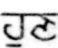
ਹੁਣ
